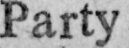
Party
